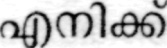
എനിക്ക്
